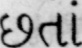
છતાં
